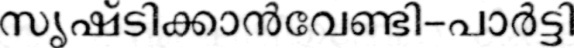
സൃഷ്ടിക്കാന്‍വേണ്ടി-പാര്‍ട്ടി
